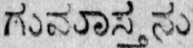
ಗುಮಾಸ್ತನು
